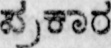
ಪ್ರಕಾರ
